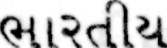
ભારતીય
